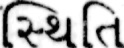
સ્થિતિ
